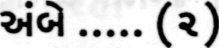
અંબિ..........(૨)
